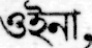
ওইনা,
